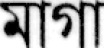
মাগা
